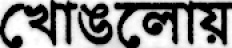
খোঙলোয়
